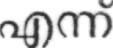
എന്ന്
